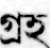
গ্রহ
